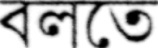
বলতে
